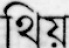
থিয়
